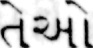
તેઓ
